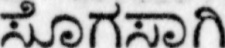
ಸೊಗಸಾಗಿ
